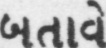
બતાવે
